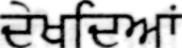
ਦੇਖਦਿਆਂ
